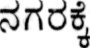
ನಗರಕ್ಕೆ
